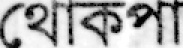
থোকপা
